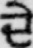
ਦੇ
